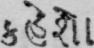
કહેશો
